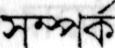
সম্পর্ক
